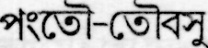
পংতৌ-তৌবসু
